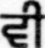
ਵੀ
